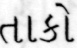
તાકો
